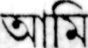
আমি
